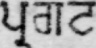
ਪ੍ਰਗਟ
